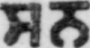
ਸਨ
